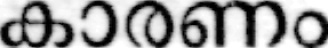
കാരണം
